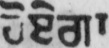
ਹੋਏਗਾ
